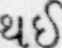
થઈ
